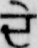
ਦੇ
